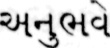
અનુભવે
